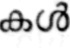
കള്‍
